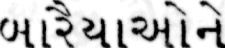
બારૈયાઓને
